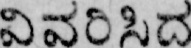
ವಿವರಿಸಿದ
